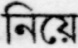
নিয়ে
